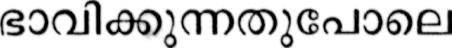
ഭാവിക്കുന്നതുപോലെ
